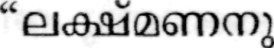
"ലക്ഷ്മണനു
